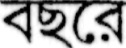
বছরে
